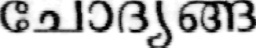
ചോദ്യങ്ങ
